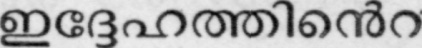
ഇദ്ദേഹത്തിന്റെ
